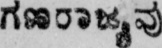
ಗಣರಾಜ್ಯವು
